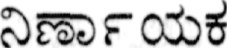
ನಿರ್ಣಾಯಕ
